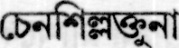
চেনশিল্লক্তুনা
